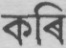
কৰি
